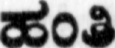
ಹಂತಿ
